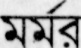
মর্মর
